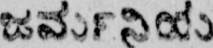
ಜರ್ಮನಿಯ
